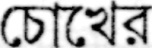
চোখের
